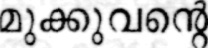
മുക്കുവന്റെ
